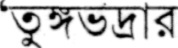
‘তুঙ্গভদ্রার
